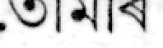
তোমাৰ
